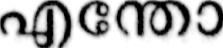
എന്തോ
